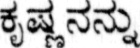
ಕೃಷ್ಣನನ್ನು
